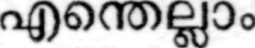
എന്തെല്ലാം
